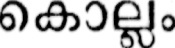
കൊല്ലം
